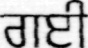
ਗਈ
